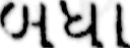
બધા
